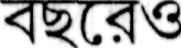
বছরেও
